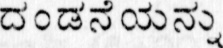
ದಂಡನೆಯನ್ನು
